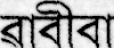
ৱাবীবা
